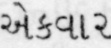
એકવાર
